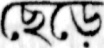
ছেড়ে
